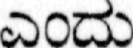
ಎಂದು
